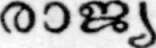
രാജ്യ
